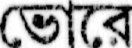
ভোরে
